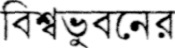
বিশ্বভুবনের
